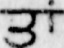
ਤਾਂ
